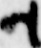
ન
